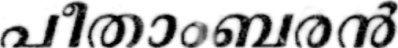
പീതാംബരന്‍
